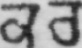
ਕਰ
